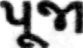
પૂજા
